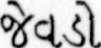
જેવડો
